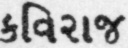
કવિરાજ
